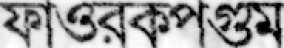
ফাওরকপগুম
